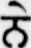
ਨੇ
